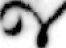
જ
